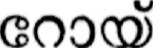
റോയ്
